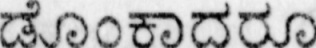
ಡೊಂಕಾದರೂ
